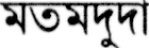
মতমদুদা
